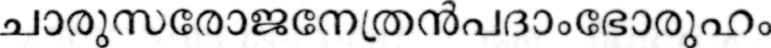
ചാരുസരോജനേത്രന്‍പദാംഭോരുഹം
